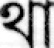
থা
